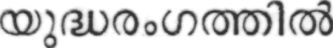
യുദ്ധരംഗത്തില്‍
